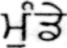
ਮੁੰਡੇ
